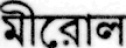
মীরোল
